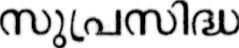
സുപ്രസിദ്ധ
